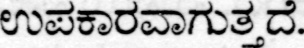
ಉಪಕಾರವಾಗುತ್ತದೆ.
